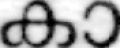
കാ
